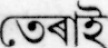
তেৰাই
